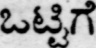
ಒಟ್ಟಿಗೆ
